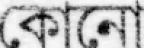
কোনো
